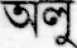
অলু
